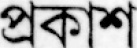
প্রকাশ
